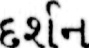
દર્શન
